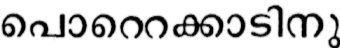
പൊറെറക്കാടിനു
